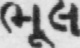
ભૂલ
